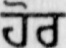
ਹੋਰ
